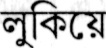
লুকিয়ে
